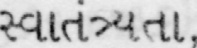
સ્વાતંત્ર્યતા,
